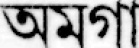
অমগা
